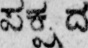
ಪಕ್ಷದ
